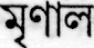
মৃণাল
